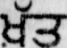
ਖ਼ੱਤ
